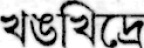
খঙখিদ্রে
